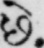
છે.
